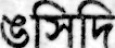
ঙসিদি
